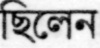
ছিলেন
